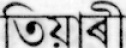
তিয়াৰী
